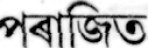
পৰাজিত
